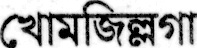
খোমজিল্লগা
